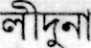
লীদুনা
